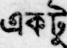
একটু
